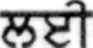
ਲਈ
